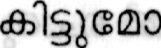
കിട്ടുമോ
